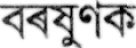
বৰষুণক
